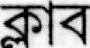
ক্লাব
